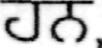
ਹਨ,
